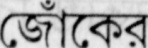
জোঁকের
